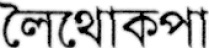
লৈথোকপা
